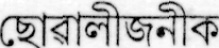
ছোৱালীজনীক
